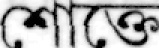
শোক্তে
